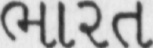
ભારત
